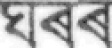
ঘৰৰ
